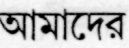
আমাদের
